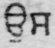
ਉਸ
